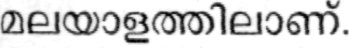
മലയാളത്തിലാണ്.
